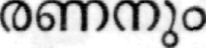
രണനും
